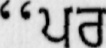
''ਪਰ
